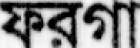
ফরগা
